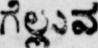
ಗೆಲ್ಲುವ
